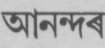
আনন্দৰ
